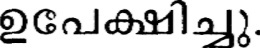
ഉപേക്ഷിച്ചു.
